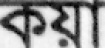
কয়া
